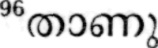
96താണു
